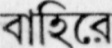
বাহিরে
